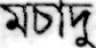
মচাদু
